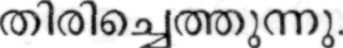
തിരിച്ചെത്തുന്നു.
